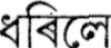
ধৰিলে
